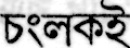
চংলকই
